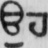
ਉਹ
